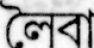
লৈবা
